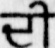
ਦੀ
